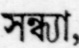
সন্ধ্যা,
